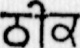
ਠੀਕ
